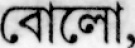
বোলো,
